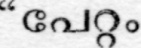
"പേറ്റം
